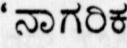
‘ನಾಗರಿಕ
